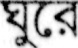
ঘুরে
